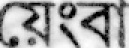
য়েংবা
